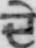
ਦੇ
